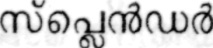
സ്പ്ലെന്‍ഡര്‍
